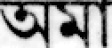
অমা
